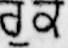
ਰੁਕ
